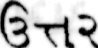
ઉત્તર
